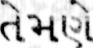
તેમણે
